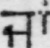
ਜਾਂ
